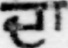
ਦਾ
